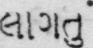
લાગતું
